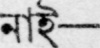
নাই—
